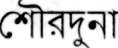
শৌরদুনা
